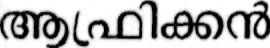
ആഫ്രിക്കന്‍
